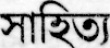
সাহিত্য
